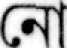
নো
